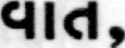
વાત,
